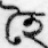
হৈ
